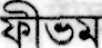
ফীভম
